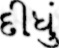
દીધું
